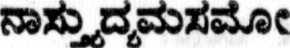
ನಾಸ್ತ್ಯುದ್ಯಮಸಮೋ
